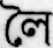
লৈ
